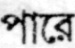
পারে
